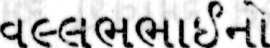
વલ્લભભાઈનો
